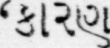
'કારણ
